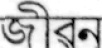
জীৱন
